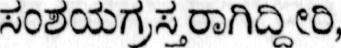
ಸಂಶಯಗ್ರಸ್ತರಾಗಿದ್ದೀರಿ,
